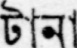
টানা
